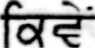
ਕਿਵੇਂ
